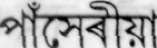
পাঁসেৰীয়া
